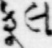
ફુલ
